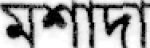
মশাদা
